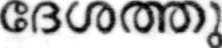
ദേശത്തു
